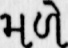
મળે
